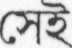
সেই
